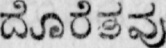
ದೊರೆತವು
